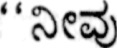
"ನೀವು
